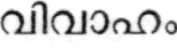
വിവാഹം
